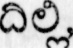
ದಿಲ್ಲಿ,
